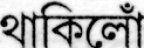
থাকিলোঁ
